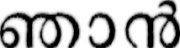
ഞാന്‍
